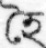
হৈ
